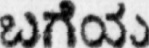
ಬಗೆಯ
